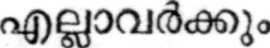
എല്ലാവര്‍ക്കും
